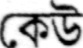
কেউ
